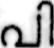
പി
